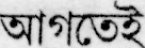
আগতেই
